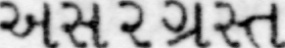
અસરગ્રસ્ત
